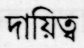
দায়িত্ব
